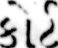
કોર્ટ
